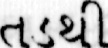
તડથી
